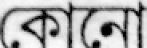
কোনো
